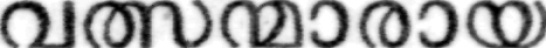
വത്സന്മാരായ
